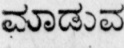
ಮಾಡುವ
